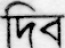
দিব
